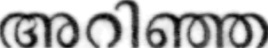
അറിഞ്ഞ
